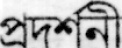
প্রদৰ্শনী
